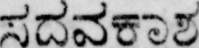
ಸದವಕಾಶ
